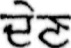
ਦੇਣ
